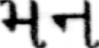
મન
